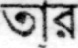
তার
